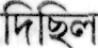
দিছিল
